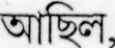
আছিল,
